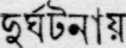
দুর্ঘটনায়
